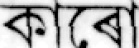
কাৰো
